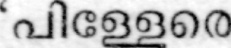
‘പിള്ളേരെ
